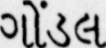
ગોંડલ
